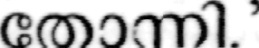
തോന്നി.'
